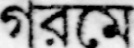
গরমে
